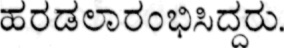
ಹರಡಲಾರಂಭಿಸಿದ್ದರು.
